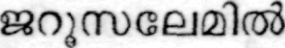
ജറൂസലേമില്‍
